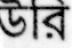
উরি
